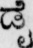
ಡೈ
